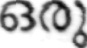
ഒരു
